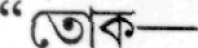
"তোক-
